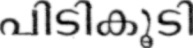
പിടികൂടി
